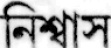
নিশ্বাস
